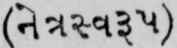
(નેત્રસ્વરૂપ)
